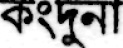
কংদুনা
